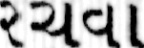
રચવા
